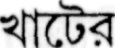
খাটের
